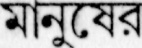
মানুষের
